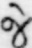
જે
